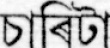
চাৰিটা
